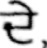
ਦੇ,
